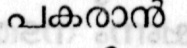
പകരാന്‍
